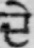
ਦੇ
